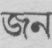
জন
